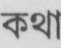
কথা
